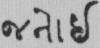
જનોઈ
